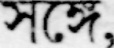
সঙ্গে,
